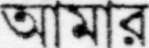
আমার
